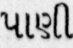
પાણી
